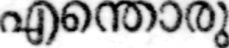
എന്തൊരു
